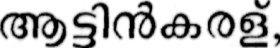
ആട്ടിന്‍കരള്,
